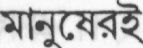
মানুষেরই
